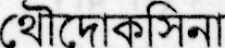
থৌদোকসিনা
